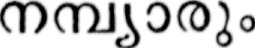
നമ്പ്യാരും
